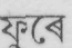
ফুৰে
